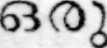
ഒരു
